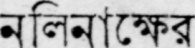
নলিনাক্ষের
